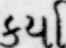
કર્યા
